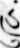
હું
